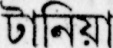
টানিয়া
